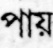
পায়
